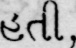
હતી,
